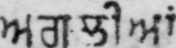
ਅਗਲੀਆਂ
